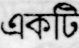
একটি
